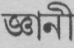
জ্ঞানী
